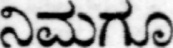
ನಿಮಗೂ
